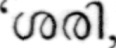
'ശരി,
